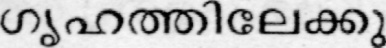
ഗൃഹത്തിലേക്കു
